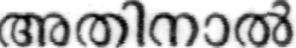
അതിനാല്‍
